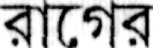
রাগের
